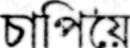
চাপিয়ে
